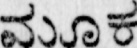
ಮೂಕ
